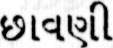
છાવણી
